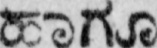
ಹಾಗೂ
